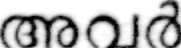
അവര്‍
